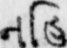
નહિ
